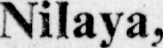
Nilaya,
